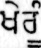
ਖੇਰੂੰ
